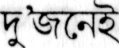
দু'জনেই
